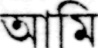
আমি
